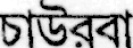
চাউরবা
